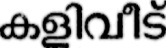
കളിവീട്
